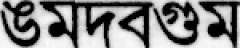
ঙমদবগুম
